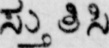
ಸ್ತುತಿಸಿ
